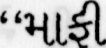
"માફી
